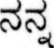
ನನ್ನ
